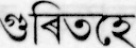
গুৰিতহে
